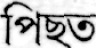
পিছত
